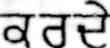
ਕਰਦੇ
